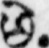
છે.
